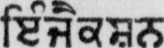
ਇੰਜੈਕਸ਼ਨ
